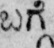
ಬಗ್ಗೆ
